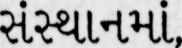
સંસ્થાનમાં,
